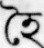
হৈ
